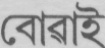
বোৱাই
